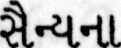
સૈન્યના
